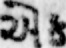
એક
